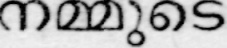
നമ്മുടെ
